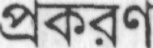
প্রকরণ
